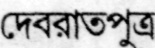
দেবরাতপুত্র
